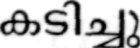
കടിച്ചു
